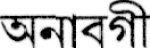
অনাবগী
